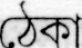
ঠেকা
